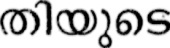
തിയുടെ
